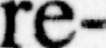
re-
